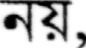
নয়,
